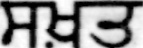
ਸਖ਼ਤ
